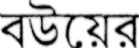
বউয়ের
